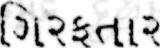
ગિરફતાર
